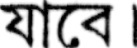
যাবে।
